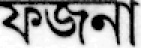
ফজনা
